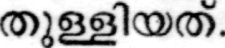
തുള്ളിയത്.
